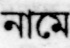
নামে
